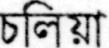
চলিয়া
